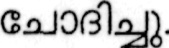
ചോദിച്ചു.
